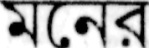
মনের
